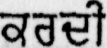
ਕਰਦੀ
